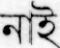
নাই
